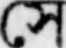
সে
